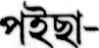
পইছা-
